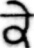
ਕੇ
